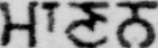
ਮਾਣਨ
